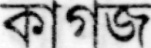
কাগজ
